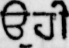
ਉਹੀ
